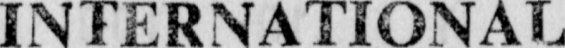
INTERNATIONAL
